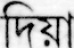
দিয়া
